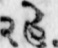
રહે.
